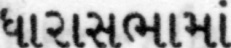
ધારાસભામાં
